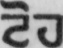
ਟੋਹ
